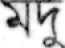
মদু
